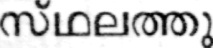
സ്ഥലത്തു
